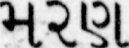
મરણ
